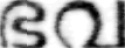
ഭവ
